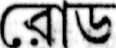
রোড
